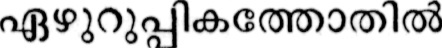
ഏഴുറുപ്പികത്തോതില്‍
